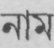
নাম
